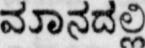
ಮಾನದಲ್ಲಿ
